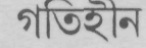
গতিহীন
